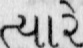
ત્યારે
